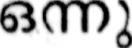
ഒന്നു
